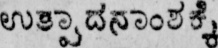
ಉತ್ಪಾದನಾ೦ಶಕ್ಕೆ
